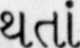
થતાં
